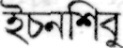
ইচনশিবু
